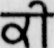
ਕੀ
